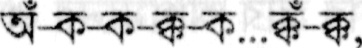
অঁ-ক-ক-ক্ক-ক...ক্কঁ-ক্ক,
